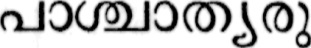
പാശ്ചാത്യരു
